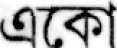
একো
